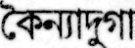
কৈন্যাদুগা
